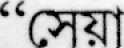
"সেয়া
